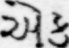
એક
